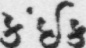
કંઈક
